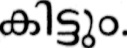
കിട്ടും.
